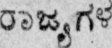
ರಾಜ್ಯಗಳ
